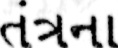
તંત્રના
